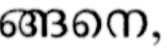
ങ്ങനെ,
